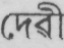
দেৱী
